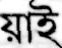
য়াই
